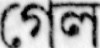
গেল
